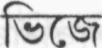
ভিজে
